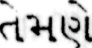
તેમણે
